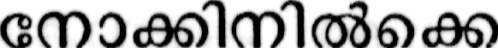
നോക്കിനില്‍ക്കെ
